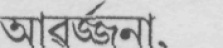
আৱৰ্জ্জনা,
